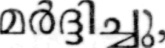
മര്‍ദ്ദിച്ചു,
